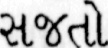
સજતો
